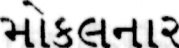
મોકલનાર
